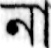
না
